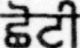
ਛੋਟੀ
